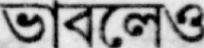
ভাবলেও
